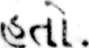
હતો.
